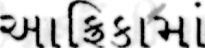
આફ્રિકામાં
